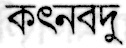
কৎনবদু
